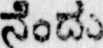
ನೆಂದು
